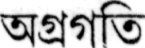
অগ্রগতি
